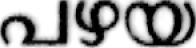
പഴയ
